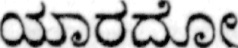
ಯಾರದೋ
